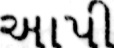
આપી
